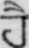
ਹੈ
